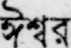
ঈশ্বর
